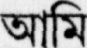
আমি
